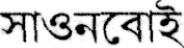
সাওনবোই
